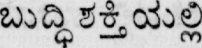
ಬುದ್ಧಿಶಕ್ತಿಯಲ್ಲಿ
